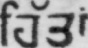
ਹਿੱਤਾਂ
